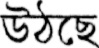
উঠছে
